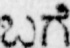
ಬಗೆ
